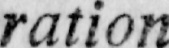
ration
